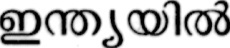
ഇന്ത്യയില്‍
